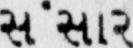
સંસાર
